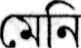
মেনি
